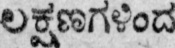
ಲಕ್ಷಣಗಳಿಂದ
